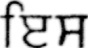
ਇਸ
